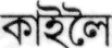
কাইলৈ
